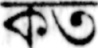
কত
